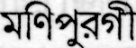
মণিপুরগী
